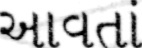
આવતાં
